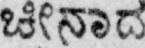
ಚೀನಾದ
